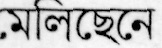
মেলিছেনে
